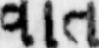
વાત
